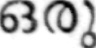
ഒരു
